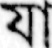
যা
